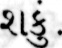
શકું.
